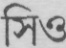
সিও
